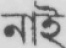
নাই
